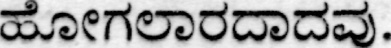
ಹೋಗಲಾರದಾದವು.
